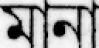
মানা
